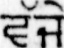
ਵੱਜੇ
